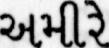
અમીરે
